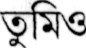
তুমিও
